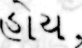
હોય,
